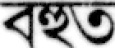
বহুত
